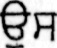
ਉਸ
